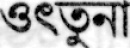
ওৎতুনা
